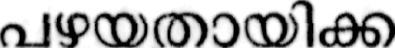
പഴയതായിക്ക
